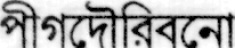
পীগদৌরিবনো
